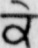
ਕੇ
